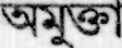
অমুক্তা
